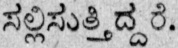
ಸಲ್ಲಿಸುತ್ತಿದ್ದರೆ.
